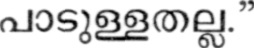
പാടുള്ളതല്ല."
